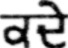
ਕਦੇ
